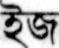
ইজ
